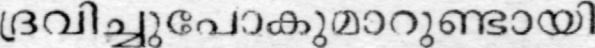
ദ്രവിച്ചുപോകുമാറുണ്ടായി
